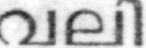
വലി
